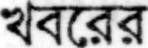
খবরের
